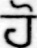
ਹੋ
